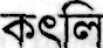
কৎলি
